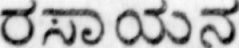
ರಸಾಯನ
